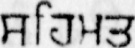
ਸਹਿਮਤ
